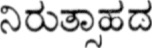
ನಿರುತ್ಸಾಹದ
